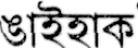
ঙাইহাক
